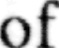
of
